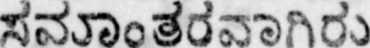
ಸಮಾಂತರವಾಗಿರು
